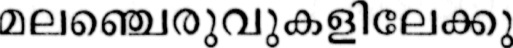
മലഞ്ചെരുവുകളിലേക്കു
